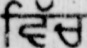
ਵਿੱਚ
